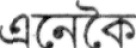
এনেকৈ
